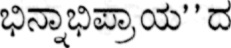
ಭಿನ್ನಾಭಿಪ್ರಾಯ"ದ
